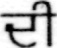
ਦੀ
